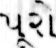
પૂરો
